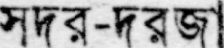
সদর-দরজা
